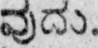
ವುದು.
